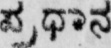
ಪ್ರಧಾನ
